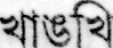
খাঙখি
